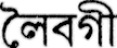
লৈবগী
